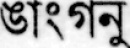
ঙাংগনু
